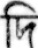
দি
